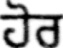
ਹੋਰ
